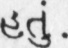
હતું.
